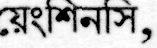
য়েংশিনসি,
